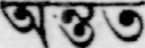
অন্তত
